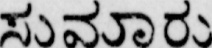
ಸುಮಾರು
